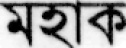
মহাক
